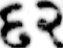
દર
